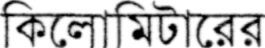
কিলোমিটারের
